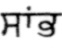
ਸਾਂਭ
